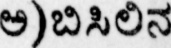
ಅ)ಬಿಸಿಲಿನ
